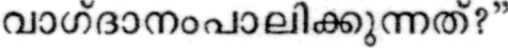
വാഗ്‌ദാനംപാലിക്കുന്നത്?”
